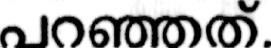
പറഞ്ഞത്.
